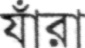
যাঁরা
